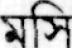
মসি
